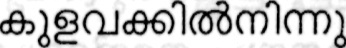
കുളവക്കില്‍നിന്നു
